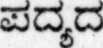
ಪದ್ಯದ
